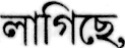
লাগিছে,
